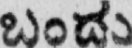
ಬಂದು
